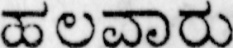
ಹಲವಾರು
